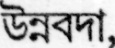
উন্নবদা,
